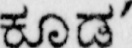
ಕೂಡ’
